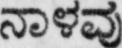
ನಾಳವು
